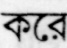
করে
